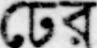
ঢের
